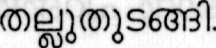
തല്ലുതുടങ്ങി.
